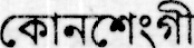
কোনশেংগী
